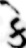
કે
